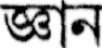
জ্ঞান
